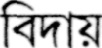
বিদায়
